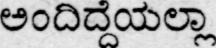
ಅಂದಿದ್ದೆಯಲ್ಲಾ
